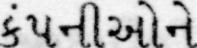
કંપનીઓને
